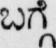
ಬಗ್ಗೆ
